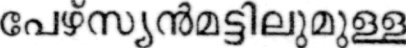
പേഴ്സ്യന്‍മട്ടിലുമുള്ള
